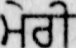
ਮੇਰੀ
